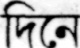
দিনে
